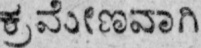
ಕ್ರಮೇಣವಾಗಿ
